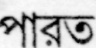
পারত
